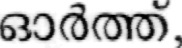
ഓര്‍ത്ത്,
